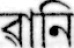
ৱানি
